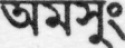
অমসুং
